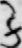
કે
